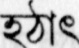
হঠাৎ
